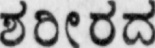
ಶರೀರದ
